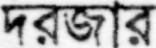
দরজার
